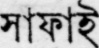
সাফাই
